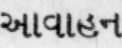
આવાહન
